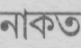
নাকত
